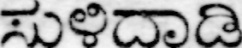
ಸುಳಿದಾಡಿ
